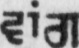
ਵਾਂਗ
